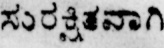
ಸುರಕ್ಷಿತವಾಗಿ
